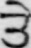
ਤੇ
